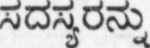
ಸದಸ್ಯರನ್ನು
